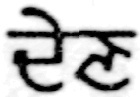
ਦੇਣ
